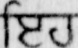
ਇਹ
